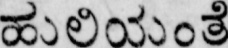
ಹುಲಿಯಂತೆ
